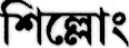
শিল্লোং
